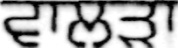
ਵਾਲੜਾ
